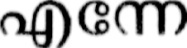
എന്നേ
